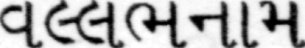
વલ્લભનામ
